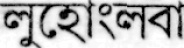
লুহোংলবা
